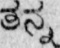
ತನ್ನ
